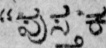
“ಪುಸ್ತಕ
